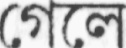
গেলে
